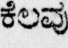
ಕೆಲವು
